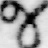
જ
